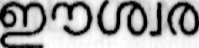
ഈശ്വര
